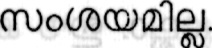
സംശയമില്ല.
